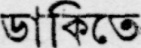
ডাকিতে
